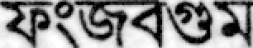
ফংজবগুম
